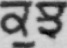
ਕੁਝ
